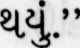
થયું."
